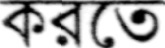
করতে
